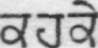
ਕਹਕੇ
